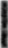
I
